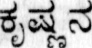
ಕೃಷ್ಣನ
